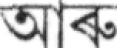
আৰু
